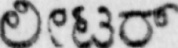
ಲೀಟರ್
